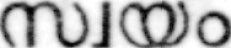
സ്വയം
